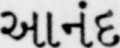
આનંદ
